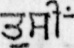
ਤੁਸੀਂ
